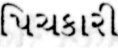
પિચકારી
